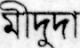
মীদুদা
